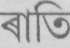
ৰাতি
